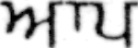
ਆਪ
